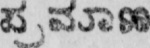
ಪ್ರಮಾಣ
